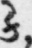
કે,
